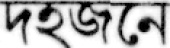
দহজনে
